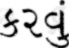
કરવું
